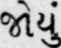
જોયું
